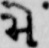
મેં
